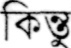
কিন্তু
